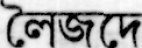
লৈজদে
